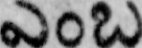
ಎಂಬ
